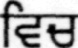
ਵਿਚ
